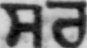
ਸਰ
